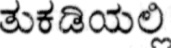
ತುಕಡಿಯಲ್ಲಿ
